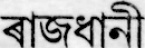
ৰাজধানী
